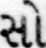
સો
